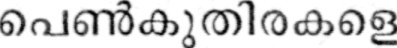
പെണ്‍കുതിരകളെ
